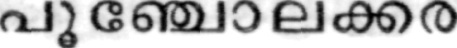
പൂഞ്ചോലക്കര
